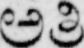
ಅತಿ
